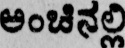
ಅಂಚಿನಲ್ಲಿ
